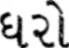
ધરો
